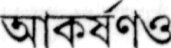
আকর্ষণও
